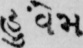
હુવેમ
